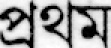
প্রথম
